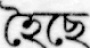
হৈছে
